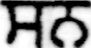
ਸਨ
